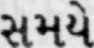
સમયે
